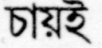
চায়ই
